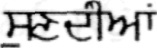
ਸੁਣਦੀਆਂ
